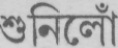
শুনিলোঁ
